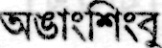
অঙাংশিংবু
